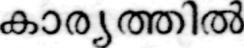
കാര്യത്തില്‍
